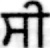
ਸੀ
